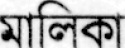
মালিকা
